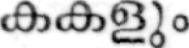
കകളും
